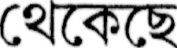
থেকেছে
